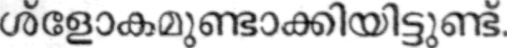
ശ്ളോകമുണ്ടാക്കിയിട്ടുണ്ട്.
